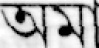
অমা
